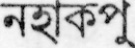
নহাকপু
